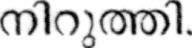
നിറുത്തി.
